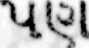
પણ
